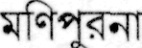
মণিপুরনা
